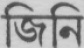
জিনি
